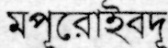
মপূরোইবদূ
